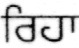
ਰਿਹਾ
